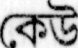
কেউ
